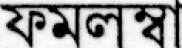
ফমলম্বা
